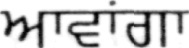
ਆਵਾਂਗਾ
